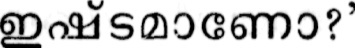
ഇഷ്ടമാണോ?’
